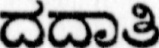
ದದಾತಿ
